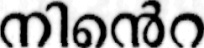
നിന്റെ
